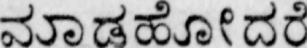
ಮಾಡಹೋದರೆ
